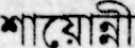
শায়োন্নী
